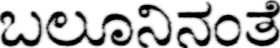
ಬಲೂನಿನಂತೆ
